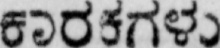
ಕಾರಕಗಳು
